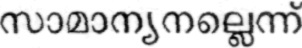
സാമാന്യനല്ലെന്ന്
